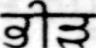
ਭੀੜ
